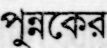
পুন্নকের
